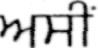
ਅਸੀਂ
